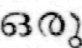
ഒരു
